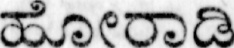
ಹೋರಾಡಿ
